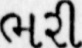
ભરી
